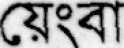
য়েংবা
